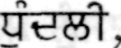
ਧੁੰਦਲੀ,
